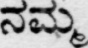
ನಮ್ಮ
